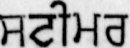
ਸਟੀਮਰ
